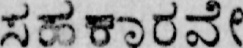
ಸಹಕಾರವೇ
